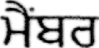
ਮੈਂਬਰ
